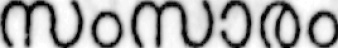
സംസാരം
